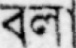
বলা
